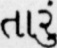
તારું
